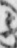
કે
